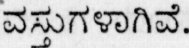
ವಸ್ತುಗಳಾಗಿವೆ.
